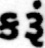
કરૂં
